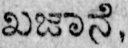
ಖಜಾನೆ,
